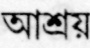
আশ্রয়
